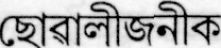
ছোৱালীজনীক
